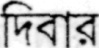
দিবার
